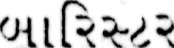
બારિસ્ટર
